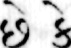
છેકે
